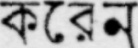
করেন
